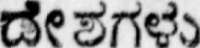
ದೇಶಗಳು
